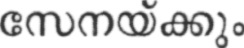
സേനയ്ക്കും
